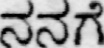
ನನಗೆ
